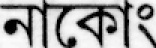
নাকোং
